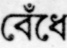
বেঁধে
